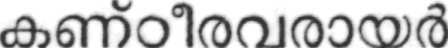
കണ്ഠീരവരായര്‍
